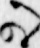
જે
